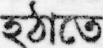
হঠাতে
